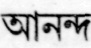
আনন্দ
